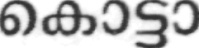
കൊട്ടാ
